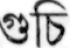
গুচি
